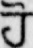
ਹੋ
